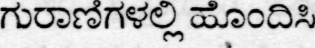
ಗುರಾಣಿಗಳಲ್ಲಿಹೊಂದಿಸಿ
